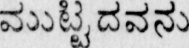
ಮುಟ್ಟಿದವನು
